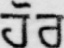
ਹੋਰ
